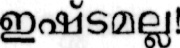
ഇഷ്ടമല്ല!
